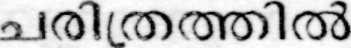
ചരിത്രത്തില്‍
